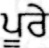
ਪੂਰੇ
